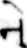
ને
